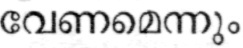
വേണമെന്നും
